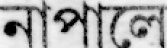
নাপালে
